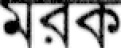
মরক
